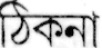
ঠিকনা
